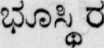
ಭೂಸ್ಥಿರ
